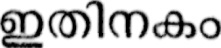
ഇതിനകം
